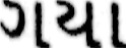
ગયા
